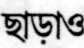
ছাড়াও
